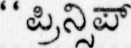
“ಪ್ರಿನ್ಸಿಪ್
